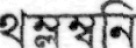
থম্লম্বনি
